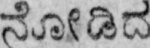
ನೋಡಿದ
